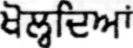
ਖੋਲ੍ਹਦਿਆਂ
